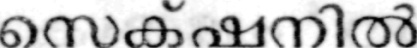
സെക്ഷനില്‍
